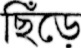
ছিঁড়ে
